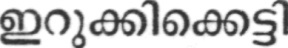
ഇറുക്കിക്കെട്ടി
